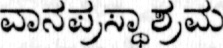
ವಾನಪ್ರಸ್ಥಾಶ್ರಮ
